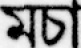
মচা
